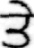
ਤੇ
